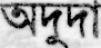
অদুদা
